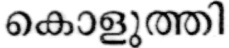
കൊളുത്തി
